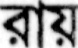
রায়
